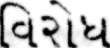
વિરોધ
